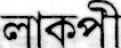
লাকপী
